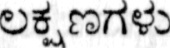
ಲಕ್ಷಣಗಳು
